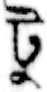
ডা
